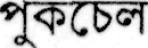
পুকচেল
